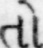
તો
